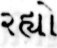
રહ્યો
